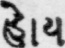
હોય
